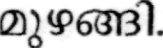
മുഴങ്ങി.
